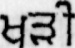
ਖੜੀ
